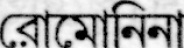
রোমোনিনা
